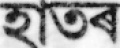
হাতৰ
